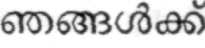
ഞങ്ങള്‍ക്ക്
